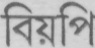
বিয়পি
